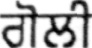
ਗੋਲੀ
